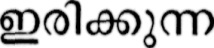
ഇരിക്കുന്ന
